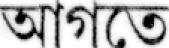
আগতে
